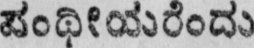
ಪಂಥೀಯರೆಂದು
